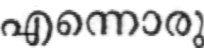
എന്നൊരു
